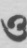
ও
